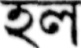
হল
